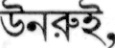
উনরুই,
